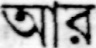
আর
